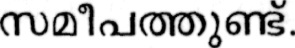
സമീപത്തുണ്ട്.
